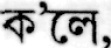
ক'লে,
